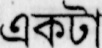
একটা
